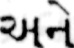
અને
